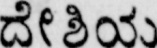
ದೇಶಿಯ
